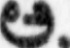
ಅ.
